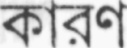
কারণ
